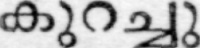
കുറച്ചു
